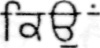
ਕਿਉਂ
